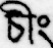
চীং
